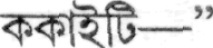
ককাইটি-"
